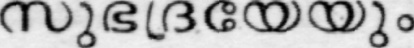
സുഭദ്രയേയും
